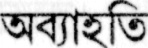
অব্যাহতি
